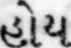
હોય
